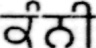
ਕੰਨੀ
